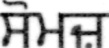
ਸੋਮਜ਼
